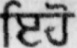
ਇਹੋ
